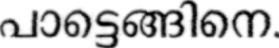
പാട്ടെങ്ങിനെ.
